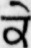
ਕੇ
